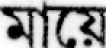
মায়ে
